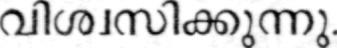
വിശ്വസിക്കുന്നു.
